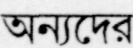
অন্যদের
